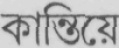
কান্তিয়ে
